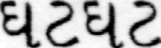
ઘટઘટ
